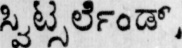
ಸ್ವಿಟ್ಸರ್ಲೆಂಡ್,
